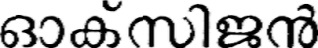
ഓക്സിജന്‍
